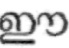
ഈ
